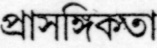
প্রাসঙ্গিকতা
